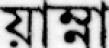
য়াম্না
